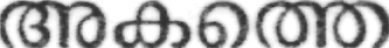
അകത്തെ
